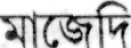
মাজেদি
